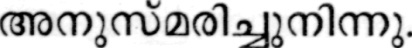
അനുസ്മരിച്ചുനിന്നു.
